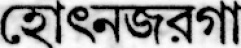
হোৎনজরগা
